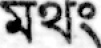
মথং
